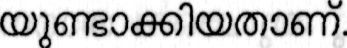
യുണ്ടാക്കിയതാണ്.
